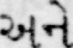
અને
